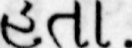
હતા.
